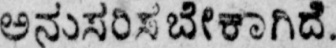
ಅನುಸರಿಸಬೇಕಾಗಿದೆ.
